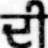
ਦੀ
